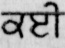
ਕਈ
